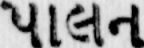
પાલન
